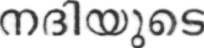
നദിയുടെ
